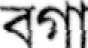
বগা
